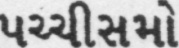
પચ્ચીસમો
